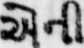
એની
